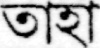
তাহা
